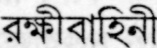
রক্ষীবাহিনী
